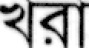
খরা
